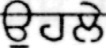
ਉਹਲੇ
